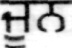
ਜੂਨ
